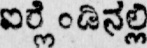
ಐರ್‍ಲೆಂಡಿನಲ್ಲಿ
